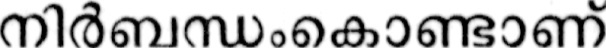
നിര്‍ബന്ധംകൊണ്ടാണ്
